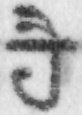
ਹੈ
